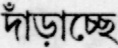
দাঁড়াচ্ছে
